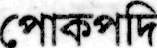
পোকপদি
